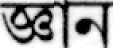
জ্ঞান
